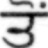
ਤੋਂ
